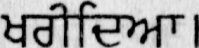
ਖਰੀਦਿਆ।
